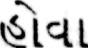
હોવા
